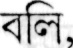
বলি,
